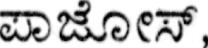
ಪಾಜೋಸ್,
